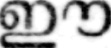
ഈ
